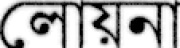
লোয়না
